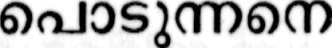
പൊടുന്നനെ
